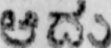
ಆದು
